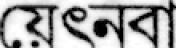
য়েৎনবা
